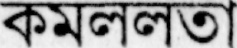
কমললতা
